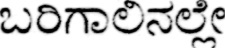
ಬರಿಗಾಲಿನಲ್ಲೇ
